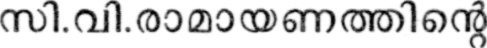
സി.വി.രാമായണത്തിന്റെ
